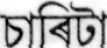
চাৰিটা
